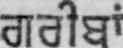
ਗਰੀਬਾਂ
